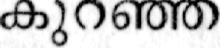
കുറഞ്ഞ
